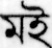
মই
